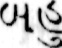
બહુ
